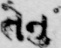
તેનુ
